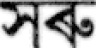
সৰু
